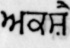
ਅਕਸ਼ੈ
